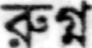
রুগ্ন
